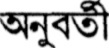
অনুবর্তী
